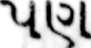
પણ
